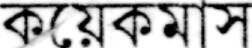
কয়েকমাস
